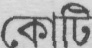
কোটি
